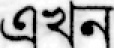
এখন
